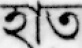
হাত
